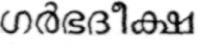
ഗര്‍ഭദീക്ഷ
